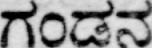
ಗಂಡನ
